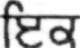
ਇਕ
